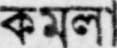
কমলা
